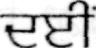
ਦਈਂ
